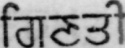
ਗਿਣਤੀ
